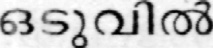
ഒടുവില്‍
